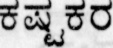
ಕಷ್ಟಕರ
